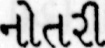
નોતરી
